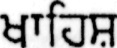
ਖਾਹਿਸ਼
